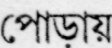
পোড়ায়
